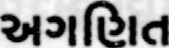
અગણિત
